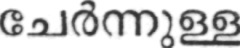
ചേര്‍ന്നുള്ള
